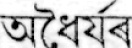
অধৈর্যৰ
